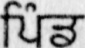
ਪਿੰਡ
